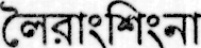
লৈরাংশিংনা
